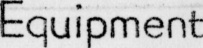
Equipment
